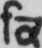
ਕਿ
